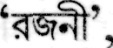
‘রজনী’,
